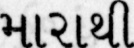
મારાથી
